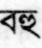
বহু
